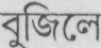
বুজিলে
